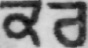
ਕਰ
